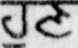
ਹੁਣ
